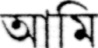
আমি
